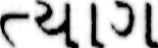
ત્યાગ
